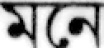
মনে
